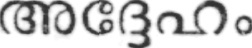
അദ്ദേഹം
